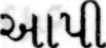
આપી
